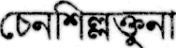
চেনশিল্লক্তুনা
